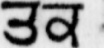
ਤਕ
